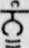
ਨੂੰ
